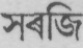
সৰজি
